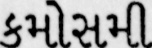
કમોસમી
